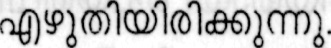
എഴുതിയിരിക്കുന്നു.
